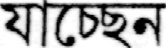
যাচ্ছেন
